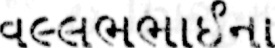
વલ્લભભાઈના
